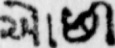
ઓછી
